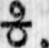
ಕಿ.
